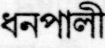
ধনপালী
